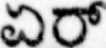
ಏರ್
